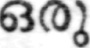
ഒരു
